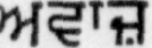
ਅਵਾਜ਼
